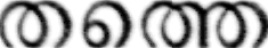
തത്തെ
